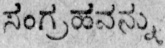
ಸಂಗ್ರಹವನ್ನು
